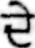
ਦੇ
